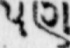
પણ
